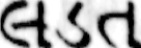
લડત
